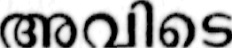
അവിടെ
